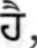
ਹੈ,
